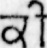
ਕੀ
